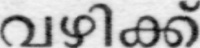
വഴിക്ക്
